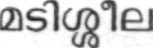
മടിശ്ശീല
